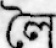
লৈ
